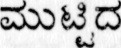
ಮುಟ್ಟಿದ
